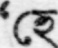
‘হে
